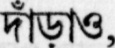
দাঁড়াও,
